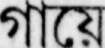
গায়ে
